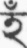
হঁ
